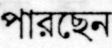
পারছেন
